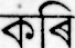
কৰি
